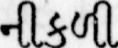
નીકળી
